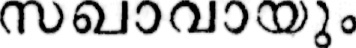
സഖാവായും
